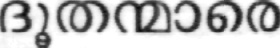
ദൂതന്മാരെ
